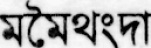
মমৈথংদা
